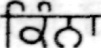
ਕਿੰਨਾ
